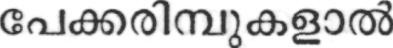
പേക്കരിമ്പുകളാല്‍
